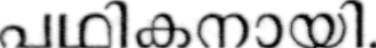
പഥികനായി.
